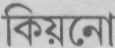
কিয়নো
